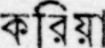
করিয়া
